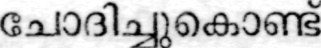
ചോദിച്ചുകൊണ്ട്
